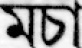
মচা
